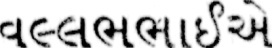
વલ્લભભાઈએ
